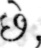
છે,
